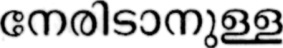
നേരിടാനുള്ള
